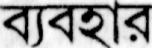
ব্যবহার
